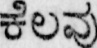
ಕೆಲವು
